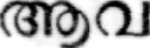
ആവ
